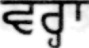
ਵਰ੍ਹਾ
